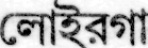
লোইরগা
